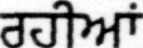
ਰਹੀਆਂ
